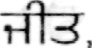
ਜੀਤ,
